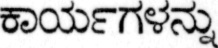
ಕಾರ್ಯಗಳನ್ನು
